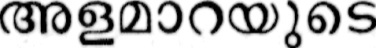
അളമാറയുടെ
